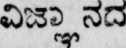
ವಿಜ್ಞಾನದ
